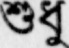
শুধু
